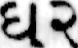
ઘર
